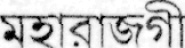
মহারাজগী
